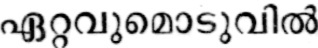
ഏറ്റവുമൊടുവില്‍
